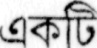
একটি
